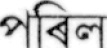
পৰিল
